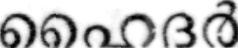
ഹൈദര്‍
